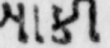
બાકી
